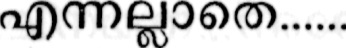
എന്നല്ലാതെ......
